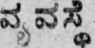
ವ್ಯವಸ್ಥೆ
